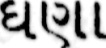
ઘણા
